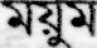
ময়ুম
